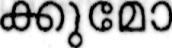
ക്കുമോ
